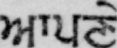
ਆਪਣੇ
